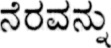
ನೆರವನ್ನು
